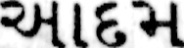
આદમ
